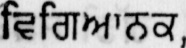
ਵਿਗਿਆਨਕ,
